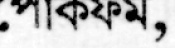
পোকফম,
